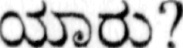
ಯಾರು?
